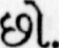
છો.
